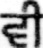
ਵੀ
